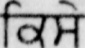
ਕਿਸੇ
